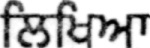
ਲਿਖਿਆ
